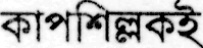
কাপশিল্লকই
